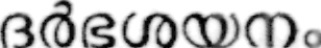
ദര്‍ഭശയനം
